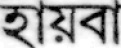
হায়বা
